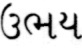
ઉભય
